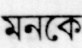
মনকে
